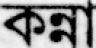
কন্না
